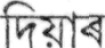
দিয়াৰ
